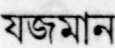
যজমান
